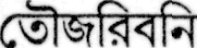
তৌজরিবনি
